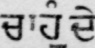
ਚਾਹੁੰਦੇ
